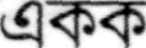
একক
